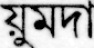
য়ুমদা
